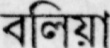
বলিয়া
